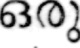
ഒരു
